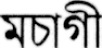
মচাগী
